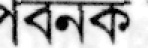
পবনক
